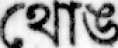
থোঙ
